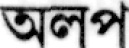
অলপ
